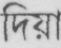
দিয়া
